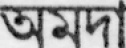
অমদা
